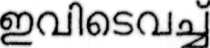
ഇവിടെവച്ച്
